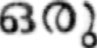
ഒരു
